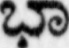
ಭಾ
